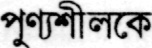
পুণ্যশীলকে
